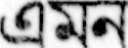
এমন
